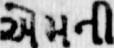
એમની
